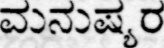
ಮನುಷ್ಯರ
